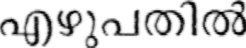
എഴുപതില്‍
